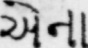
એના
